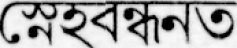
স্নেহবন্ধনত
